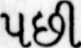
પછી
